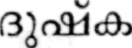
ദുഷ്ക
